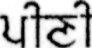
ਪੀਣੀ
